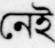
নেই
